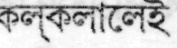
কল্‌কলালেই
